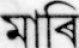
মাৰি
